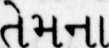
તેમના
